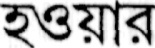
হওয়ার
